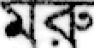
মরু
